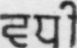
ਵਧੀ
